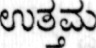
ಉತ್ತಮ
